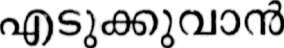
എടുക്കുവാന്‍
